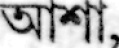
আশা,
